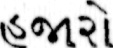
હજારો
